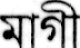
মাগী
